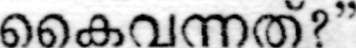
കൈവന്നത്?”
